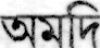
অমদি
